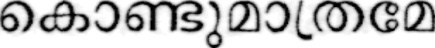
കൊണ്ടുമാത്രമേ
